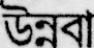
উন্নবা
